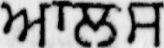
ਆਲਸ
